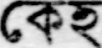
কেহ
